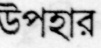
উপহার
